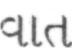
વાત
